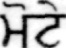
ਮੋਟੇ
